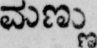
ಮಣ್ಣು
